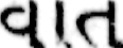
વાત
